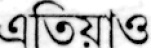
এতিয়াও
